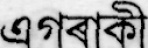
এগৰাকী
